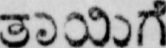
ತಾಯಿಗೆ
